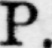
P.
